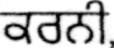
ਕਰਨੀ,
